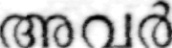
അവര്‍
